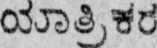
ಯಾತ್ರಿಕರ
